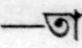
–তা
